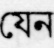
যেন
